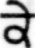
ਕੇ
